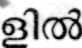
ളില്‍
